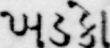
ખડકો
